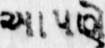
આપણે
